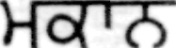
ਮਕਾਨ
